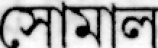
সোমাল
